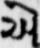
એ
